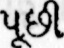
પૂછી
